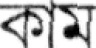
কাম
